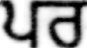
ਪਰ
